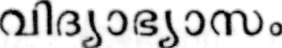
വിദ്യാഭ്യാസം
